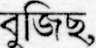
বুজিছ,
